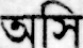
অসি
